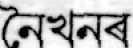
নৈখনৰ
